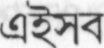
এইসব
